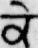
ਕੇ
